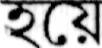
হয়ে
